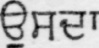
ਉਸਦਾ
